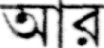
আর
